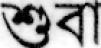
শুবা
